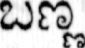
ಬಣ್ಣ
